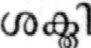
ശക്തി
